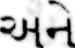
અને
